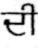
ਦੀ
